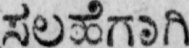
ಸಲಹೆಗಾಗಿ
